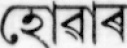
হোৱাৰ
